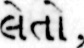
લેતો,
